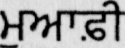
ਮੁਆਫ਼ੀ
